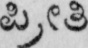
ಪ್ರೀತಿ
